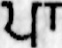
ਪਾ
